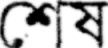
শেষ
